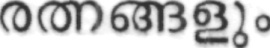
രത്നങ്ങളും
